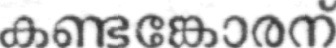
കണ്ടങ്കോരന്
